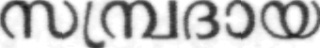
സമ്പ്രദായ
